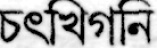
চৎখিগনি
